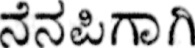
ನೆನಪಿಗಾಗಿ
